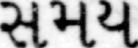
સમય
